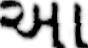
આ
